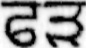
ਫੜ
